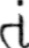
તં
